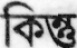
কিন্তু
